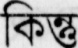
কিন্তু
